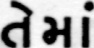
તેમાં
